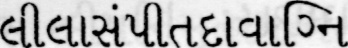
લીલાસંપીકદાવાગ્નિ
